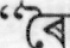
"ৰৈ
